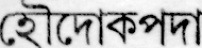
হৌদোকপদা
